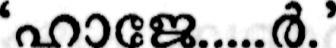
‘ഹാജേ.....ര്‍.’
